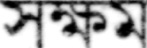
সক্ষম
